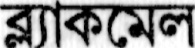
ব্ল্যাকমেল
